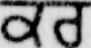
ਕਰ
